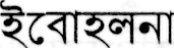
ইবোহলনা
